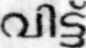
വിട്ട്
